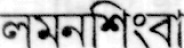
লমনশিংবা
